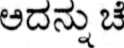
ಅದನ್ನುಚೆ
